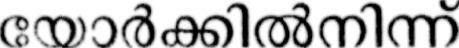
യോര്‍ക്കില്‍നിന്ന്
